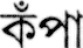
কঁপা
